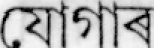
যোগাৰ
